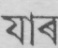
যাৰ
